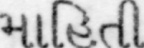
માહિતી
